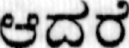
ಆದರೆ
